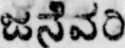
ಜನವರಿ
